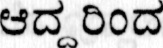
ಆದ್ದರಿಂದ
